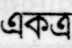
একত্র
